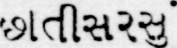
છાતીસરસું
